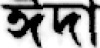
ঈদা
